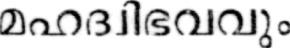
മഹദ്വിഭവവും
